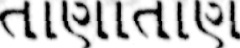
તાણાતાણ
